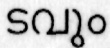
ടവും
